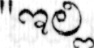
“ಇಲ್ಲಿ
